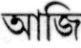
আজি
